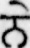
ਨੇ
